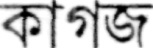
কাগজ
